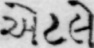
એટલે
